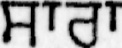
ਸਾਰਾ
